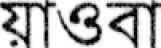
য়াওবা
